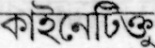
কাইনেটিক্তু
